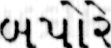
બપોરે
